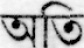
অতি
